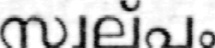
സ്വല്പം
